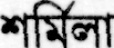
শর্মিলা
